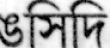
ঙসিদি
